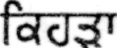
ਕਿਹੜਾ
